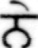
ਨੇ
